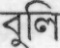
বুলি
